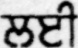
ਲਈ
